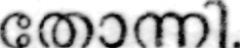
തോന്നി.
